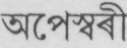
অপেস্বৰী
